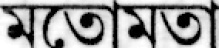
মতোমতা
